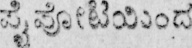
ಪೈಪೋಟಿಯಿಂದ
